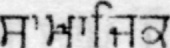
ਸਾਮਾਜਿਕ
